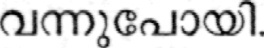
വന്നുപോയി.
